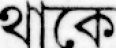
থাকে
